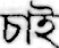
চাই
